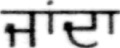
ਜਾਂਦਾ
